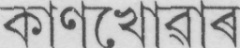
কাণখোৱাৰ
